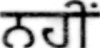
ਨਹੀਂ
